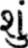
શું
